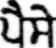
ਪੈਸੇ
